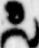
ಸಿ
